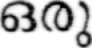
ഒരു
